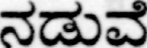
ನಡುವೆ
